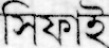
সিফাই
